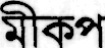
মীকপ
